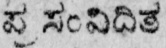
ಪ್ರಸಂವಿದಿತ
